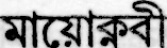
মায়োক্নবী
